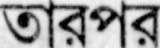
তারপর
